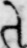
તે
